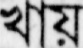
খায়
